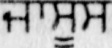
ਜਾਸੂਸ
